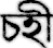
চহী
